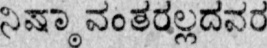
ನಿಷ್ಠಾವಂತರಲ್ಲದವರ
